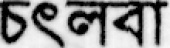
চৎলবা
